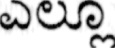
ಎಲ್ಲೂ
